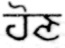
ਹੋਣ
